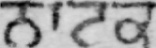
ਨਾਟਕ
